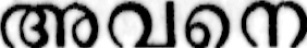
അവനെ
